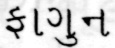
ફાગુન
